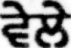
ਵੇਲੇ
